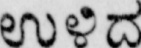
ಉಳಿದ
